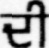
ਦੀ
